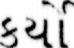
કર્યો
